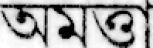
অমত্তা
